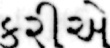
કરીએ
